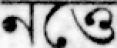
নত্তে
